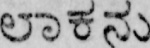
ಲಾಕನು
